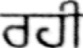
ਰਹੀ
